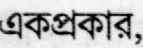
একপ্রকার,
